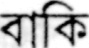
বাকি
